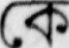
কে
